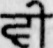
ਵੀ
